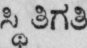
ಸ್ಥಿತಿಗತಿ
